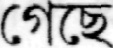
গেছে
